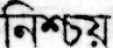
নিশ্চয়
